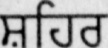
ਸ਼ਹਿਰ
